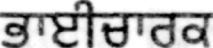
ਭਾਈਚਾਰਕ
